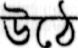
উঠে
